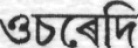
ওচৰেদি
